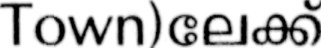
Town)ലേക്ക്
